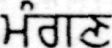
ਮੰਗਣ
